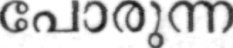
പോരുന്ന
